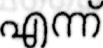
എന്ന്
